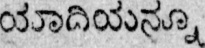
ಯಾದಿಯನ್ನೂ
